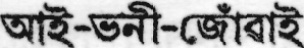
আই-ভনী-জোঁৱাই
